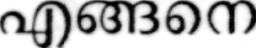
എങ്ങനെ
